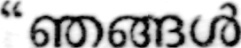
“ഞങ്ങള്‍
